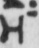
ਮੈਂ
